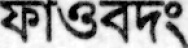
ফাওবদং
